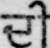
ਦੀ
